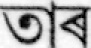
তাৰ
